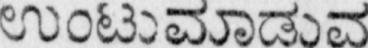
ಉಂಟುಮಾಡುವ
